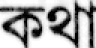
কথা
